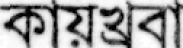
কায়খ্রবা
